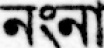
নংনা
